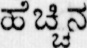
ಹೆಚ್ಚಿನ
